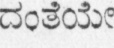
ದಂತೆಯೇ
